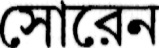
সোরেন
